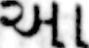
આ
